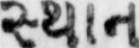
સ્થાન
